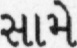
સામે
